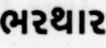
ભરથાર
